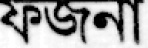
ফজবা
